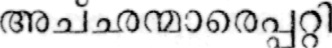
അച്ഛന്മാരെപ്പറ്റി
